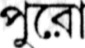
পুরো
